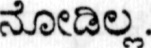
ನೋಡಿಲ್ಲ.
